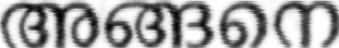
അങ്ങനെ
